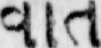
વાત
